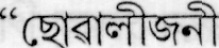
"ছোৱালীজনী
